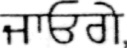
ਜਾਓਗੇ,
